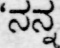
‘ನನ್ನ
